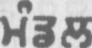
ਮੰਡਲ
